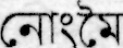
নোংমৈ
